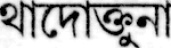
থাদোক্তুনা
